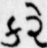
કરે
